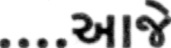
.......આજે
